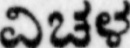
ವಿಚಳ
